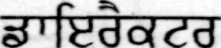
ਡਾਇਰੈਕਟਰ
